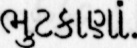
ભુટકાણાં.
